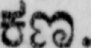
ಕಣ.
